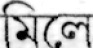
মিলে
